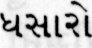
ધસારો
